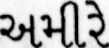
અમીરે
